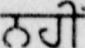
ਨਹੀਂ
